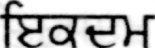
ਇਕਦਮ
